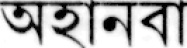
অহানবা
